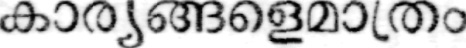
കാര്യങ്ങളെമാത്രം
